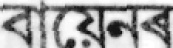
বায়েনৰ
